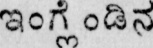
ಇಂಗ್ಲೆಂಡಿನ
